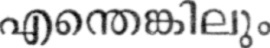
എന്തെങ്കിലും
